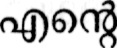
എന്റെ
